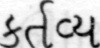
કર્તવ્ય
